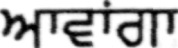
ਆਵਾਂਗਾ
